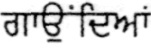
ਗਾਉਂਦਿਆਂ
